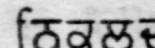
ਨਿਕਲਦ
